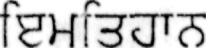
ਇਮਤਿਹਾਨ
